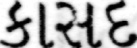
કાસદ
